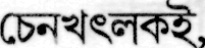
চেনখৎলকই,
